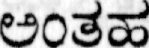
ಅಂತಹ
